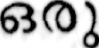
ഒരു
